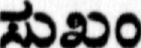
ಸುಖಂ
